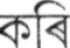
কৰি
